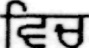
ਵਿਚ
